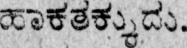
ಹಾಕತಕ್ಕುದು.
